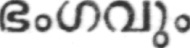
ഭംഗവും
